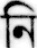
নি
